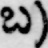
ಬ)
